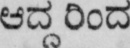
ಆದ್ದರಿಂದ
